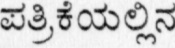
ಪತ್ರಿಕೆಯಲ್ಲಿನ
